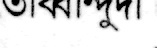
তাবান্দুদা
